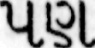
પણ
